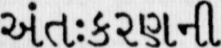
અંતઃકરણની
